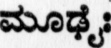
ಮೂಢೈಃ
